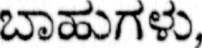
ಬಾಹುಗಳು,
